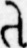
તે
